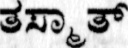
ತಸ್ಮಾತ್
